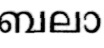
ബലാ
